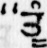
''ਤੂੰ
